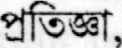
প্রতিজ্ঞা,
